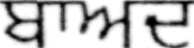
ਬਾਅਦ
